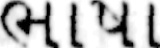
ભાષા
